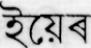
ইয়েৰ
